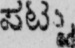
ಪಟ್ಟು
